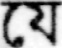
যে
